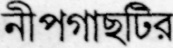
নীপগাছটির
